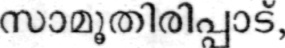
സാമൂതിരിപ്പാട്,
